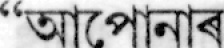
"আপোনাৰ
